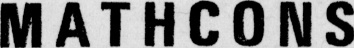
MATHCONS
